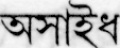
অসাইধ
